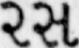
રસ
